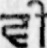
ਵੀ
